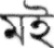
মই
